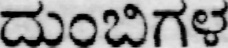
ದುಂಬಿಗಳ
